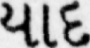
યાદ
